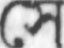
সে
